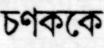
চণককে
